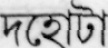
দহোটা
